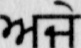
ਅਜੇ
